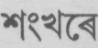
শংখৰে
